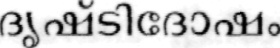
ദൃഷ്ടിദോഷം
